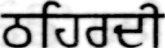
ਠਹਿਰਦੀ
